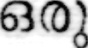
ഒരു
